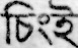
চিংই
